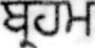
ਬ੍ਰਹਮ
